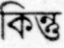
কিন্তু
